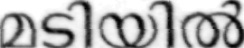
മടിയില്‍
